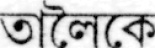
তালৈকে
